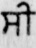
ਸੀ
